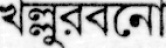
খল্লুরবনো
